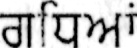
ਗਧਿਆਂ
